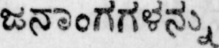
ಜನಾಂಗಗಳನ್ನು
